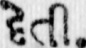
દેતી.
